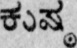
ಕುಷ್ಠ
